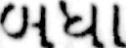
બધા
